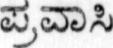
ಪ್ರವಾಸಿ
